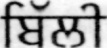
ਬਿੱਲੀ
